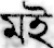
মই
